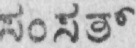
ಸಂಸತ್
